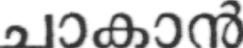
ചാകാന്‍
